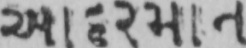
આદરમાન
